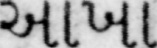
આખા
